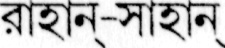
রাহান্-সাহান্
